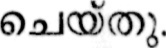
ചെയ്തു.
